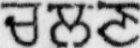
ਚਲਣ
